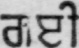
ਗਈ
